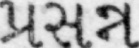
પ્રસન્ન
